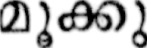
മൂക്കു
